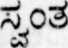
ಸ್ವಂತ
